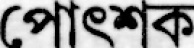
পোৎশক
